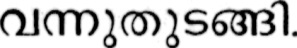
വന്നുതുടങ്ങി.
